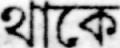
থাকে
